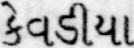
કેવડીયા
